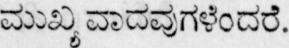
ಮುಖ್ಯವಾದವುಗಳೆಂದರೆ.
